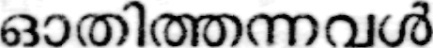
ഓതിത്തന്നവള്‍
